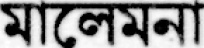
মালেমনা
